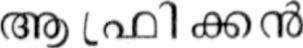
ആഫ്രിക്കന്‍
